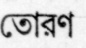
তোরণ
